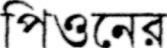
পিওনের
